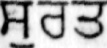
ਸੁਰਤ
